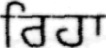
ਰਿਹਾ
